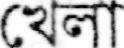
খেলা
